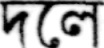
দলে
